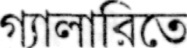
গ্যালারিতে
